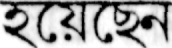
হয়েছেন
